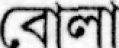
বোলা
